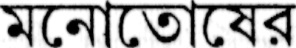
মনোতোষের
